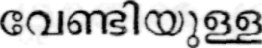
വേണ്ടിയുള്ള
